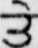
ਤੇ
